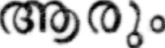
ആരും
